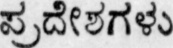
ಪ್ರದೇಶಗಳು
